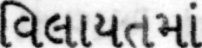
વિલાયતમાં
